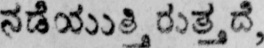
ನಡೆಯುತ್ತಿರುತ್ತದೆ,
